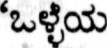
‘ಒಳ್ಳೆಯ
